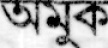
অমুক
